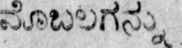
ಮೊಬಲಗನ್ನು
